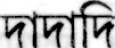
দাদাদি
